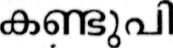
കണ്ടുപി
